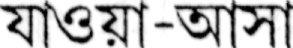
যাওয়া-আসা
